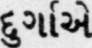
દુર્ગાએ
